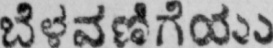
ಬೆಳವಣಿಗೆಯು
